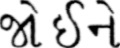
જોઈને
